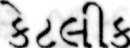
કેટલીક
